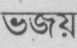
ভজয়
